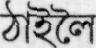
ঠাইলৈ
